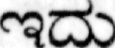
ಇದು
